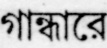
গান্ধারে
